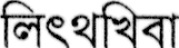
লিৎথখিবা
